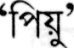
‘পিয়ু’
